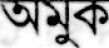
অমুক
